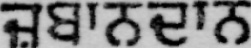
ਜ਼ਬਾਨਦਾਨ
